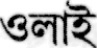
ওলাই
